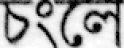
চংলে
